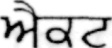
ਐਕਟ
